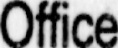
Office
